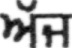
ਅੱਜ
